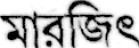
মারজিৎ
